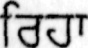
ਰਿਹਾ
